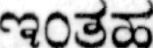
ಇಂತಹ
